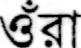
ওঁরা
